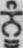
ਨੂੰ
